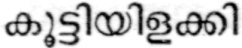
കൂട്ടിയിളക്കി
